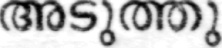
അടുത്തു
